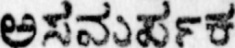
ಅಸಮರ್ಪಕ
